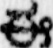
ಈ
